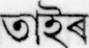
তাইৰ
